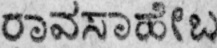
ರಾವಸಾಹೇಬ
